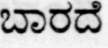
ಬಾರದೆ
